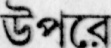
উপরে
